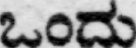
ಒ೦ದು
